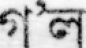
গ'ল
